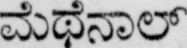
ಮೆಥೆನಾಲ್
